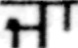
ਜਾ
